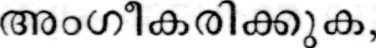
അംഗീകരിക്കുക,
